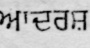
ਆਦਰਸ਼
